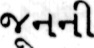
જૂનની
